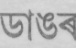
ডাঙৰ
